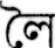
লৈ
